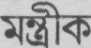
মন্ত্ৰীক
